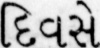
દિવસે
